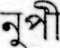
নুপী
